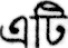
এটি
